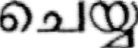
ചെയ്യ
